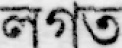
লগত
